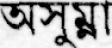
অসুম্না
